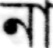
না
